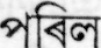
পৰিল
